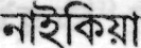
নাইকিয়া
